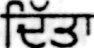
ਦਿੱਤਾ
